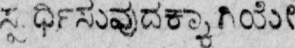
ಸ್ಪರ್ಧಿಸುವುದಕ್ಕಾಗಿಯೇ
